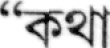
"কথা
